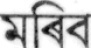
মৰিব
